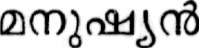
മനുഷ്യന്‍
